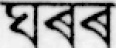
ঘৰৰ
